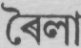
ৰৈলা
